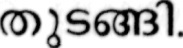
തുടങ്ങി.
